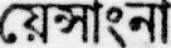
য়েন্সাংনা
